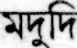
মদুদি
